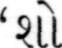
'શો
